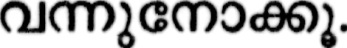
വന്നുനോക്കൂ.
